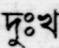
দুঃখ
